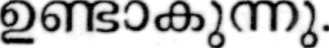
ഉണ്ടാകുന്നു.
